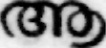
ആ
